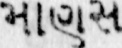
માણસ
